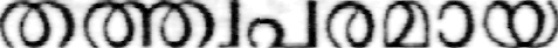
തത്ത്വപരമായ
